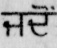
ਜਦੋਂ
